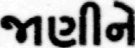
જાણીને
